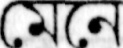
মেনে
